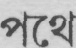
পথে
